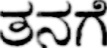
ತನಗೆ
